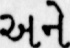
અને
